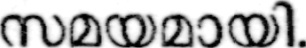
സമയമായി.
